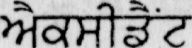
ਐਕਸੀਡੈਂਟ
